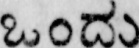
ಒಂದು
